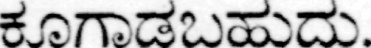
ಕೂಗಾಡಬಹುದು.
